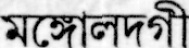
মঙ্গোলদগী
